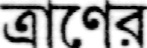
ত্রাণের
